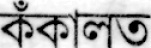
কঁকালত
